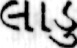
લાડુ
